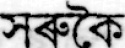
সৰুকৈ
